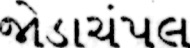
જોડાચંપલ
